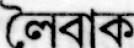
লৈবাক
